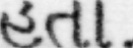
હતા.
